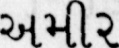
અમીર
